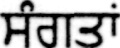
ਸੰਗਤਾਂ
